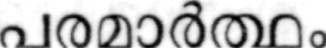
പരമാര്‍ത്ഥം
